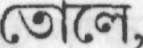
তোলে,
